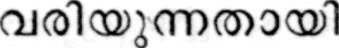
വരിയുന്നതായി
